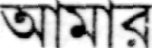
আমার
